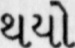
થયો
